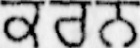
ਕਰਨ
